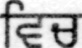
ਵਿਚ
